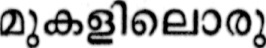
മുകളിലൊരു
